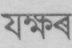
যক্ষৰ
